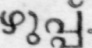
ഴുപ്പ്.
